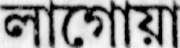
লাগোয়া
